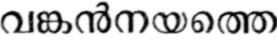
വങ്കന്‍നയത്തെ
